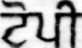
ਟੋਪੀ
